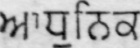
ਆਧੁਨਿਕ
